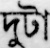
দুটা
